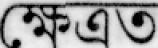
ক্ষেত্রত
